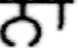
ਨਾ
